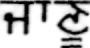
ਜਾਣੂ
